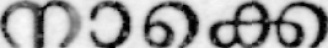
നാക്കെ
